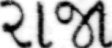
રાજા
